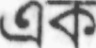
এক
